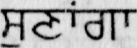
ਸੁਣਾਂਗਾ
